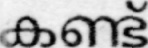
കണ്ട്
